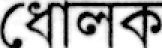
ধোলক
